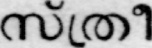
സ്ത്രീ
